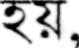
হয়,
